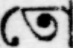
তো
